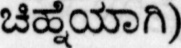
ಚಿಹ್ನೆಯಾಗಿ)
